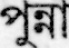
পুন্না
